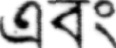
এবং
